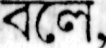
বলে,
